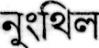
নুংথিল
